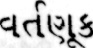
વર્તણૂક
